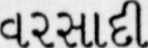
વરસાદી
